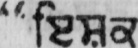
''ਇਸ਼ਕ
